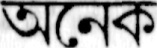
অনেক
